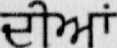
ਦੀਆਂ
